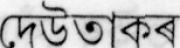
দেউতাকৰ
